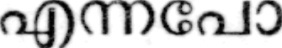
എന്നപോ
